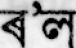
ৰ'ল
